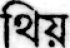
থিয়
